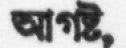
আগষ্ট,
